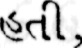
હતી,
